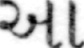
આ
